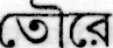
তৌরে
